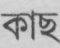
কাছ
